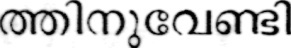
ത്തിനുവേണ്ടി
